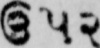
ઉપર
